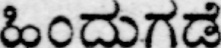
ಹಿಂದುಗಡೆ
